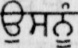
ਉਸਨੂੰ
